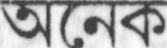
অনেক
